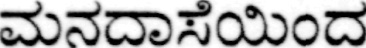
ಮನದಾಸೆಯಿಂದ
